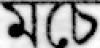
মচে
